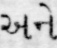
અને
